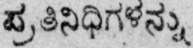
ಪ್ರತಿನಿಧಿಗಳನ್ನು
